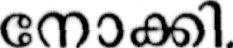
നോക്കി.
